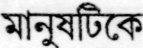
মানুষটিকে
